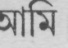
আমি
